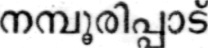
നമ്പൂരിപ്പാട്
